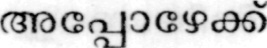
അപ്പോഴേക്ക്
